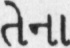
તેના
